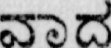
ವಾದ
